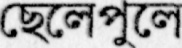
ছেলেপুলে
